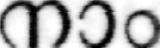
നാം
